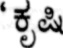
'ಕೃಷಿ
